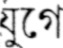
যুগে
